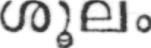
ശൂലം
